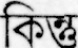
কিন্তু
